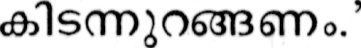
കിടന്നുറങ്ങണം.’
